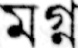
মগ্ন
